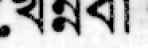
খেন্নবা
